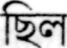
ছিল
